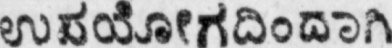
ಉಪಯೋಗದಿಂದಾಗಿ
